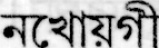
নখোয়গী
